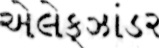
એલેક્ઝાંડર
